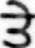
ਤੇ
